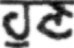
ਹੁਣ
